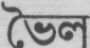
ভৈল
